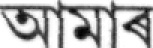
আমাৰ
